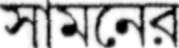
সামনের
